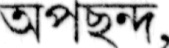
অপছন্দ,
